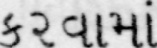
કરવામાં
